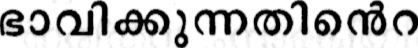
ഭാവിക്കുന്നതിന്റെ
